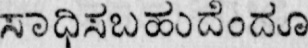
ಸಾಧಿಸಬಹುದೆಂದೂ
